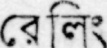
রেলিং
